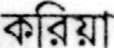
করিয়া
